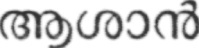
ആശാന്‍
